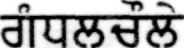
ਗੰਧਲਚੌਲੇ
